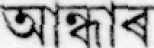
আন্ধাৰ
